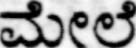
ಮೇಲೆ
